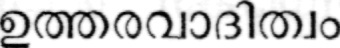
ഉത്തരവാദിത്വം
